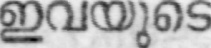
ഇവയുടെ
